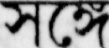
সঙ্গে
